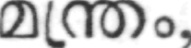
മന്ത്രം,
